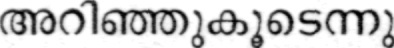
അറിഞ്ഞുകൂടെന്നു
